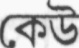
কেউ
